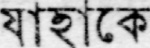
যাহাকে
